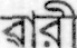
ৱারী
